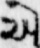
એ
